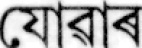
যোৱাৰ
